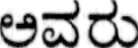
ಅವರು
